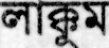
লাক্কুম
